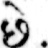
છે.
